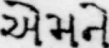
એમને
